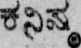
ಕನಿಷ್ಠ
